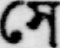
সে
